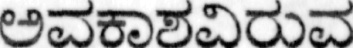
ಅವಕಾಶವಿರುವ
